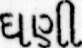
ઘણી
